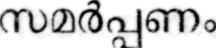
സമര്‍പ്പണം
